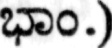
ಭಾ೦.)
